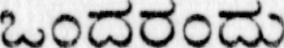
ಒಂದರಂದು
